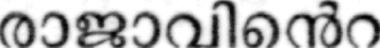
രാജാവിന്റെ
